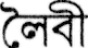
লৈবী
